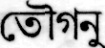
তৌগনু
